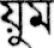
য়ুম
